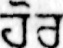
ਹੋਰ
